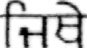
ਜਿਥੇ
